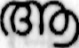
ആ
